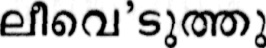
ലീവെ'ടുത്തു
